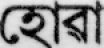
হোৱা
